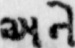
અને
